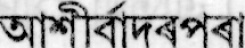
আশীর্বাদৰপৰা
